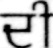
ਦੀ
